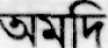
অমদি
